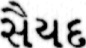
સૈયદ
